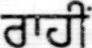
ਰਾਹੀਂ
